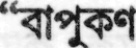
"বাপুকণ
